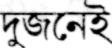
দুজনেই
